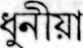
ধুনীয়া
